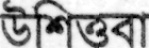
উশিত্তবা
